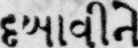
દબાવીને
